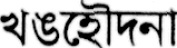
খঙহৌদনা
